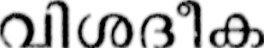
വിശദീക
